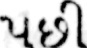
પછી
